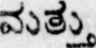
ಮತ್ತು
